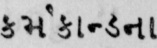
કર્મકાન્ડના
